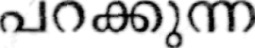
പറക്കുന്ന
